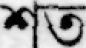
শত
